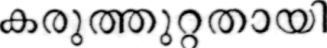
കരുത്തുറ്റതായി
